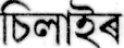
চিলাইৰ
